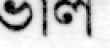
ভাল
